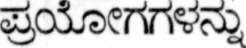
ಪ್ರಯೋಗಗಳನ್ನು
